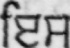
ਇਸ
